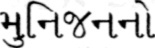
મુનિજનનો
